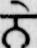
ਨੇ
